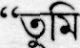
"তুমি
